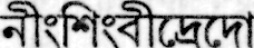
নীংশিংবীদ্রেদো
